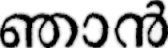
ഞാന്‍
